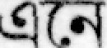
এনে
